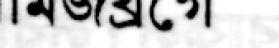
লোমজখ্রগে
